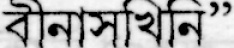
বীনাসখিনি”
